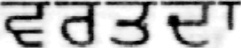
ਵਰਤਦਾ
